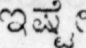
ಇಷ್ಟೇ
